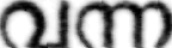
വന്ന
